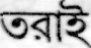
তরাই
